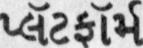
પ્લેટફૅ।ર્મ
